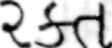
રક્ત
